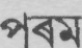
পৰম
